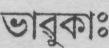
ভাৱুকাঃ
